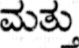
ಮತ್ತು
